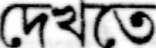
দেখতে
